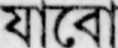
যাবো
